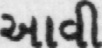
આવી
